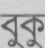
বুকু
